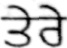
ਤੇਰੇ
